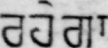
ਰਹੇਗਾ
